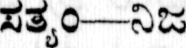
ಸತ್ಯಂ-ನಿಜ
